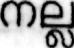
നല്ല
